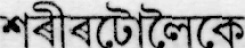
শৰীৰটোলৈকে
